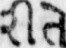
રીતે
